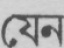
যেন
